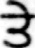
ਤੇ
